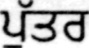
ਪੁੱਤਰ
